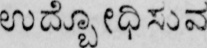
ಉದ್ಭೋಧಿಸುವ
